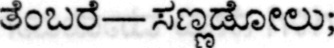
ತೆಂಬರೆ-ಸಣ್ಣಡೋಲು;
